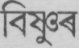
বিষ্ণুৰ
